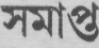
সমাপ্ত
